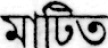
মাটিত
